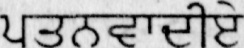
ਪਤਨਵਾਦੀਏ
